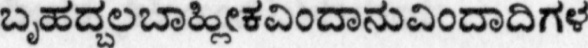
ಬೃಹದ್ಬಲಬಾಹ್ಲೀಕವಿಂದಾನುವಿದಾದಿಗಳ
